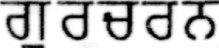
ਗੁਰਚਰਨ
